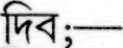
দিব;-
